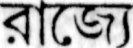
রাজ্যে
